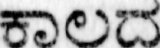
ಕಾಲದ
